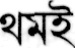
থমই
